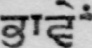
ਭਾਵੇਂ
